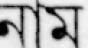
নাম
